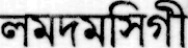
লমদমসিগী
